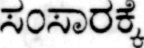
ಸಂಸಾರಕ್ಕೆ
